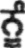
ਨੂੰ
